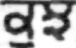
ਕੁਝ
